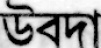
উবদা
